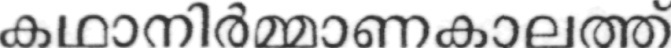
കഥാനിര്‍മ്മാണകാലത്ത്
